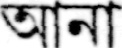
আনা
